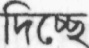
দিচ্ছে
